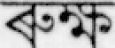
ৰুক্ষ
